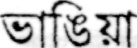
ভাঙিয়া
